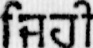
ਜਿਹੀ
